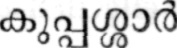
കുപ്പശ്ശാര്‍
